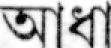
আধা
